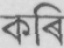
কৰি
